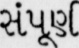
સંપૂર્ણ
